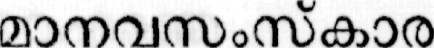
മാനവസംസ്കാര
